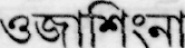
ওজাশিংনা
